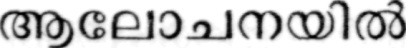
ആലോചനയില്‍
